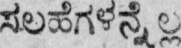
ಸಲಹೆಗಳನ್ನೆಲ್ಲ
